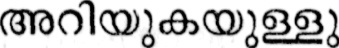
അറിയുകയുള്ളു
